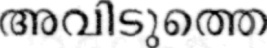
അവിടുത്തെ
